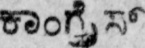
ಕಾಂಗ್ರೆಸ್
